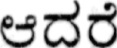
ಆದರೆ
